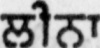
ਲੀਨਾ
